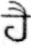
ਹੈ
